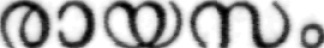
രായസം
